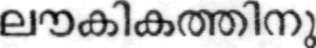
ലൌകികത്തിനു
